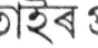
তাইৰ
